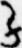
કે
